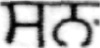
ਸਨ
